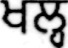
ਖਲ੍ਹ
